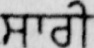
ਸਾਰੀ
